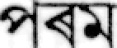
পৰম
